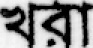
খরা
